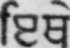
ਇਥੇ
